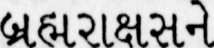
બ્રહ્મરાક્ષસને
